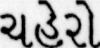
ચહેરો
